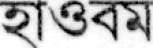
হাওবম
